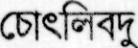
চোৎলিবদু
